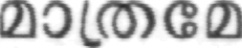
മാത്രമേ
